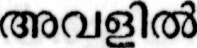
അവളില്‍
